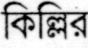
কিল্লির
